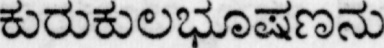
ಕುರುಕುಲಭೂಷಣನು
